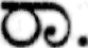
ರಾ.
